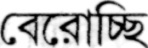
বেরোচ্ছি
